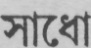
সাধো
